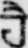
ਹੈ
